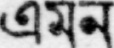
এমন
